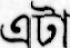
এটা
